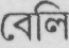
বেলি
